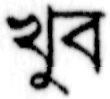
খুব
